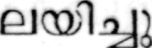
ലയിച്ചു
